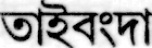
তাইবংদা
